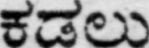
ಕಡಲು
